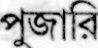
পুজারি
